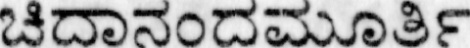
ಚಿದಾನಂದಮೂರ್ತಿ
